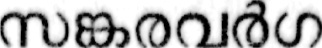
സങ്കരവര്‍ഗ
